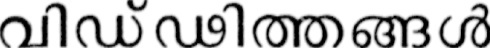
വിഡ്ഢിത്തങ്ങള്‍
